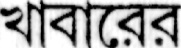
খাবারের
